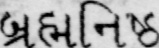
બ્રહ્મનિષ્ઠ
